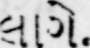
લાગે.
